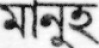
মানুহ
